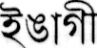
ইঙাগী
